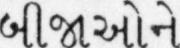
બીજાઓને
